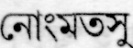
নোংমতসু
